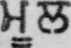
ਮੂਲ
